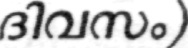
ദിവസം)
